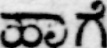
ಹಾಗೆ
